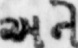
અને
